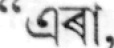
"এৰা,
